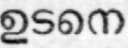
ഉടനെ
